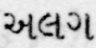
અલગ
